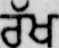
ਰੱਖ
